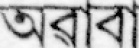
অৱাবা
